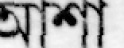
আশা
